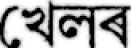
খেলৰ
